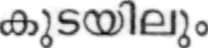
കുടയിലും
